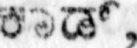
ಕಾಡ್,
